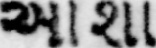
આશા
